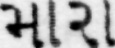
મારા
